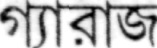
গ্যারাজ
